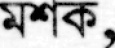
মশক,
